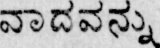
ವಾದವನ್ನು
